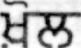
ਖ਼ੋਲ
